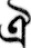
ঐ
